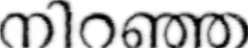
നിറഞ്ഞ
